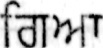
ਗਿਆ
